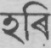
হৰি
